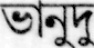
ভানুদু
